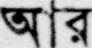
আর
